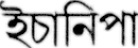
ইচানিপা
